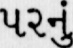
પરનું
